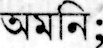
অমনি;
